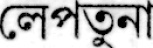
লেপতুনা
